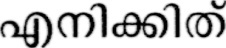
എനിക്കിത്
